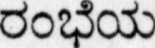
ರಂಭೆಯ
